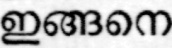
ഇങ്ങനെ
